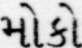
મોકો
